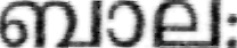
ബാല:
